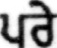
ਪਰੇ
